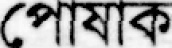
পোষাক
